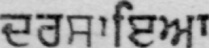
ਦਰਸਾਇਆ
